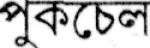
পুকচেল
